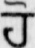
ਹੋ
